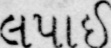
લપાઈ
